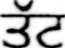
ਤੱਟ
